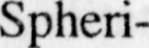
Spheri-
